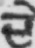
ਦੇ
